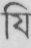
যি
